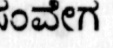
ಸಂವೇಗ
